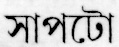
সাপটো
